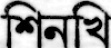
শিনখি
